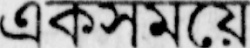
একসময়ে
